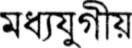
মধ্যযুগীয়
